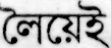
লৈয়েই
